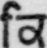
ਕਿ
